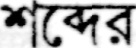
শব্দের
